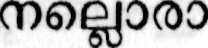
നല്ലൊരാ
